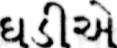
ઘડીએ
